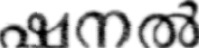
ഷനല്‍
